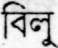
বিলু
